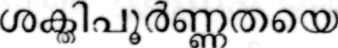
ശക്തിപൂര്‍ണ്ണതയെ
